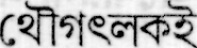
থৌগৎলকই
